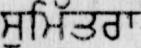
ਸੁਮਿੱਤਰਾ
